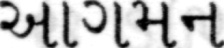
આગમન
